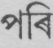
পৰি
